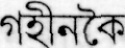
গহীনকৈ
